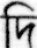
দি
